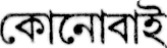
কোনোবাই
